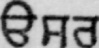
ਉਸਰ
